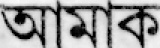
আমাক
